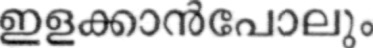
ഇളക്കാന്‍പോലും
